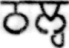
ਠਲ੍ਹ
